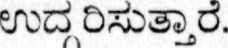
ಉದ್ಗರಿಸುತ್ತಾರೆ.
